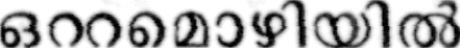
ഒററമൊഴിയില്‍
